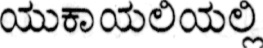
ಯುಕಾಯಲಿಯಲ್ಲಿ
